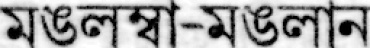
মঙলম্বা-মঙলান
